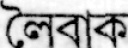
লৈবাক
